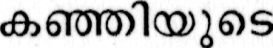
കഞ്ഞിയുടെ
